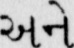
અને
